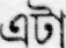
এটা
